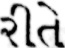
રીતે
